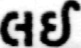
લઈ
